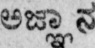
ಅಜ್ಞಾನ
